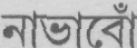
নাভাবোঁ
